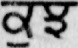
ਕੁਝ
